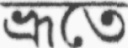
ভ্রূতে
